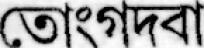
তোংগদবা
